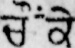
ਚੌਂਕੇ
